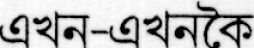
এখন-এখনকৈ
